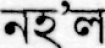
নহ'ল
